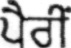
ਪੈਰੀਂ
